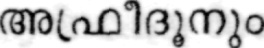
അഫ്രീദൂനും
